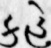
કહે
